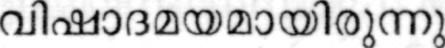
വിഷാദമയമായിരുന്നു
